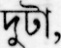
দুটা,
